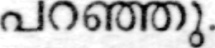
പറഞ്ഞു.
